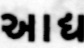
આધ
